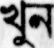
খুন
